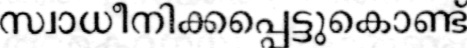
സ്വാധീനിക്കപ്പെട്ടുകൊണ്ട്
